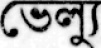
ভেল্যু
